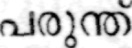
പരുന്ത്
